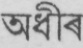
অধীৰ
